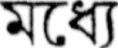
মধ্যে
